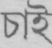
চাই
